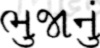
ભુજાનું
